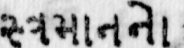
સ્વમાનનો
